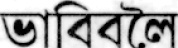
ভাবিবলৈ
